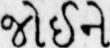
જોઈને
